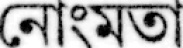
নোংমতা
